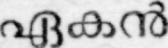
ഏകന്‍
